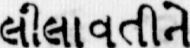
લીલાવતીને
